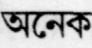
অনেক
